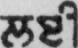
ਲਈ
